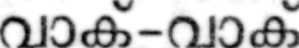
വാക്-വാക്
